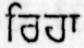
ਰਿਹਾ
